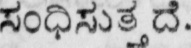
ಸಂಧಿಸುತ್ತದೆ.
